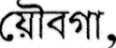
য়ৌবগা,
